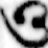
ও
